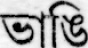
ভাঙি
